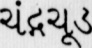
ચંદ્રચૂડ
